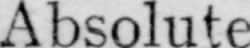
Absolute
